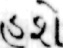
હશે
